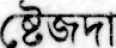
ষ্টেজদা
